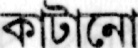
কাটানো
